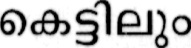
കെട്ടിലും
